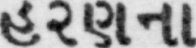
હરણના
